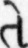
તે
